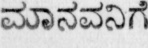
ಮಾನವನಿಗೆ
